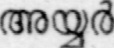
അയ്യര്‍
